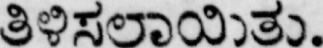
ತಿಳಿಸಲಾಯಿತು.
